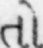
તો
